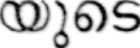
യുടെ
